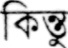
কিন্তু
